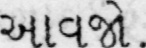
આવજો.
